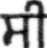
ਸੀ
